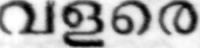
വളരെ
